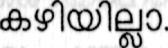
കഴിയില്ലാ.
